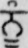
ਨੂੰ
